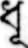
ধূ
